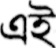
এই
